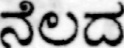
ನೆಲದ
